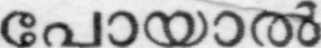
പോയാല്‍
